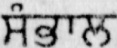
ਸੰਭਾਲ
